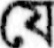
যে
